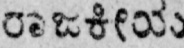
ರಾಜಕೀಯ
